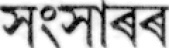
সংসাৰৰ
